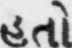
હતો
